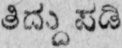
ತಿದ್ದುಪಡಿ
